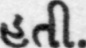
હતી.
